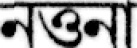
নত্তনা
